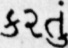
કરતું
